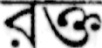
রক্ত
